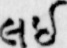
લઈ
